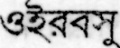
ওইরবসু
